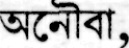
অনৌবা,
